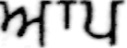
ਆਪ
